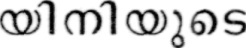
യിനിയുടെ
